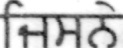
ਜਿਸਨੇ
